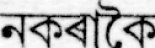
নকৰাকৈ
